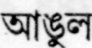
আঙুল
